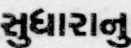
સુધારાનુ
